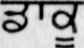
ਡਾਕੂ
